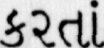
કરતાં
